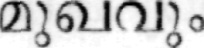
മുഖവും
